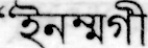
“ইনম্মগী
